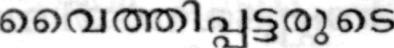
വൈത്തിപ്പട്ടരുടെ
